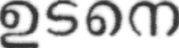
ഉടനെ
